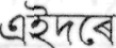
এইদৰে
